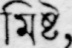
মিষ্ট,
